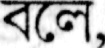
বলে,
